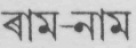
ৰাম-নাম
